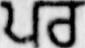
ਪਰ
